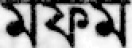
মফম
